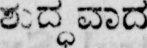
ಶುದ್ಧವಾದ
